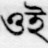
ওই
